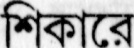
শিকারে
